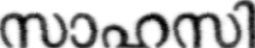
സാഹസി
